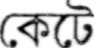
কেটে
